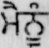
ਮੈਨੂੰ
